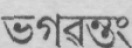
ভগৱন্তং
